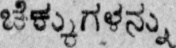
ಚೆಕ್ಕುಗಳನ್ನು
